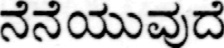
ನೆನೆಯುವುದೆ
